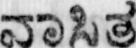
ವಾಸಿತ
